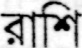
রাশি
